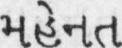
મહેનત
